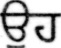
ਉਹ
